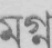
মগ্ন
